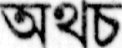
অথচ
